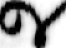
જ
